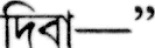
দিবা-"
